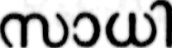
സാധി
